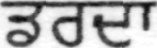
ਡਰਦਾ
